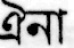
ঐনা
